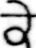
ਕੇ
